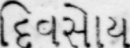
દિવસોય
